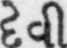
દેવી
